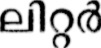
ലിറ്റര്‍
